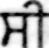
ਸੀ
